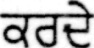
ਕਰਦੇ
